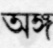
অঙ্গ
